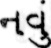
નવું
